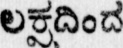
ಲಕ್ಷದಿಂದ
